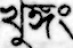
খুঙ্গং
